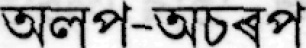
অলপ-অচৰপ
